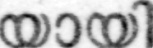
യായി
